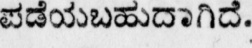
ಪಡೆಯಬಹುದಾಗಿದೆ.
